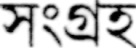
সংগ্রহ
